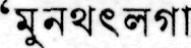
‘মুনথৎলগা
